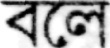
বলে
